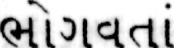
ભોગવતાં
